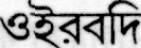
ওইরবদি
